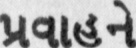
પ્રવાહને
